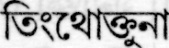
তিংথোক্তুনা
